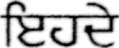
ਇਹਦੇ
